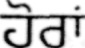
ਹੋਰਾਂ
